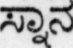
ಸ್ನಾನ
